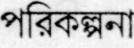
পরিকল্পনা
